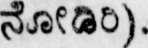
ನೋಡಿರಿ).
